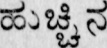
ಹುಚ್ಚಿನ
